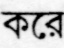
করে
